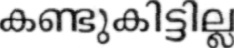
കണ്ടുകിട്ടില്ല
